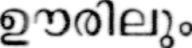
ഊരിലും
